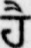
ਹੈ
